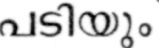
പടിയും
